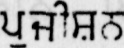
ਪੁਜੀਸ਼ਨ
